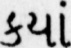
કયાં
